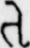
તે
